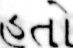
હતો
